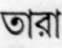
তারা
